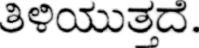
ತಿಳಿಯುತ್ತದೆ.
